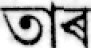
তাৰ
